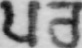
ਪਰ
